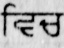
ਵਿਚ
